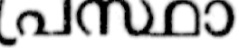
പ്രസ്ഥാ
